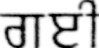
ਗਈ
